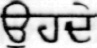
ਉਹਦੇ
